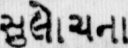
સુલોચના
